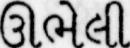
ઊભેલી
